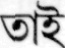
তাই
